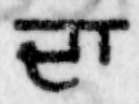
ਦਾ
